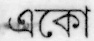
একো
